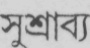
সুশ্রাব্য
